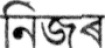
নিজৰ
